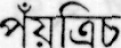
পঁয়ত্ৰিচ
